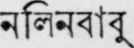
নলিনবাবু
